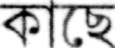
কাছে
